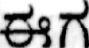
ಈಗ
